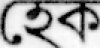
হেক
